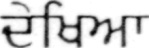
ਦੇਖਿਆ
